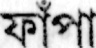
ফাঁপা
